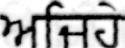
ਅਜਿਹੇ
